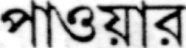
পাওয়ার
